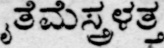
ತೆಮೆಸ್ತ್ರಳತ್ತ
